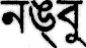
নঙবু
